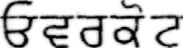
ਓਵਰਕੋਟ
